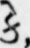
કે,
